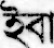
ইবা
